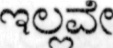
ಇಲ್ಲವೇ
